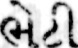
ભેટી
